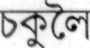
চকুলৈ
